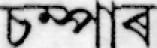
চম্পাৰ
